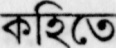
কহিতে
